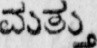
ಮತ್ತು
